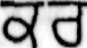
ਕਰ
